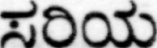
ಸರಿಯ
